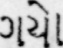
ગયો
